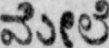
ಮೇಲೆ
